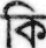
কি
